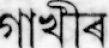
গাখীৰ
